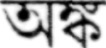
অঙ্ক
